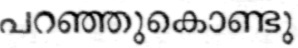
പറഞ്ഞുകൊണ്ടു
